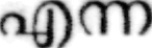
എന്ന
